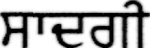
ਸਾਦਗੀ
